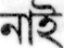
নাই
